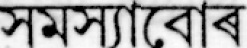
সমস্যাবোৰ
